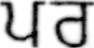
ਪਰ
